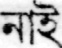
নাই
